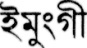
ইমুংগী
